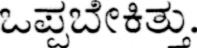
ಒಪ್ಪಬೇಕಿತ್ತು.
